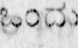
ಒಂದು
